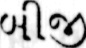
બીજી
